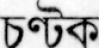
চণ্টক
